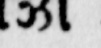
મઝા
